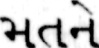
મતને
